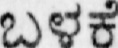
ಬಳಕೆ
